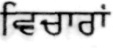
ਵਿਚਾਰਾਂ
